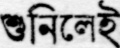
শুনিলেই
